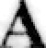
A
